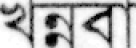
খন্নবা
